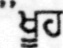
ਖੂਹ
